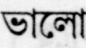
ভালো
